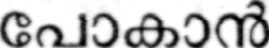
പോകാന്‍
